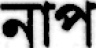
নাপ
